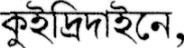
কুইদ্রিদাইনে,
